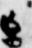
હું
